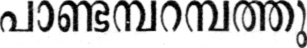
പാണ്ടമ്പറമ്പത്തു
